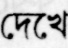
দেখে
